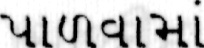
પાળવામાં
